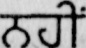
ਨਹੀਂ
